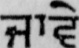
ਜਾਵੇ
